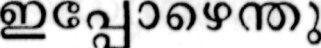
ഇപ്പോഴെന്തു
